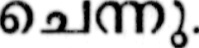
ചെന്നു.
